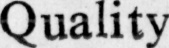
Quality
